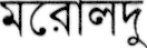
মরোলদু
